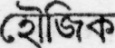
হৌজিক
